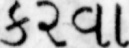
કરવા
